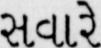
સવારે
